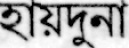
হায়দুনা
